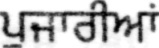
ਪੁਜਾਰੀਆਂ
